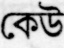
কেউ
